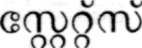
സ്റ്റേറ്റ്സ്
